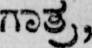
ಗಾತ್ರ,
